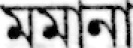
মমানা
